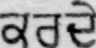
ਕਰਦੇ
